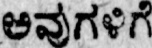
ಅವುಗಳಿಗೆ
